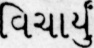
વિચાર્યું
